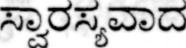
ಸ್ವಾರಸ್ಯವಾದ
